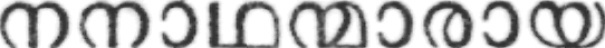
നനാഥന്മാരായ
